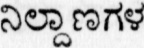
ನಿಲ್ದಾಣಗಳ
